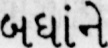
બધાંને
